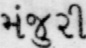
મંજુરી
